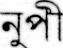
নুপী
